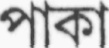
পাকা
